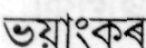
ভয়াংকৰ
